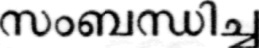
സംബന്ധിച്ച
